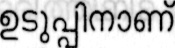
ഉടുപ്പിനാണ്
